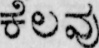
ಕೆಲವು
